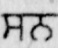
ਸਨ
